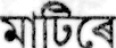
মাটিৰে
